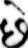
છે
